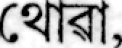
থোৱা,
